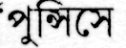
“পুন্সিসে
